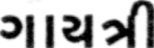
ગાયત્રી
